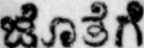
ಜೊತೆಗೆ
